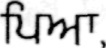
ਪਿਆ,
